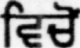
ਵਿਚੋਂ
